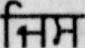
ਜਿਸ
